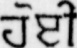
ਹੋਈ
